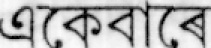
একেবাৰে
